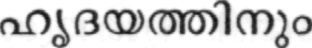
ഹൃദയത്തിനും
